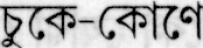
চুকে-কোণে
